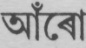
আঁৰো
